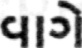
વાગે
